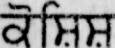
ਕੋਸ਼ਿਸ਼
